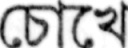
চোখে
